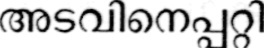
അടവിനെപ്പറ്റി
